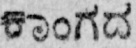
ಕಾಂಗದ
